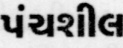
પંચશીલ
